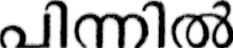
പിന്നില്‍
